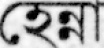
হেন্না
